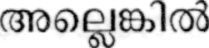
അല്ലെങ്കില്‍
